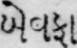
બેવફા
